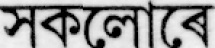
সকলোৰে
